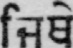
ਜਿਥੇ
